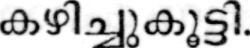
കഴിച്ചുകൂട്ടി.
